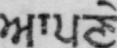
ਆਪਣੇ
